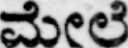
ಮೇಲೆ
